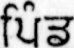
ਪਿੰਡ
